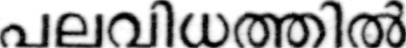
പലവിധത്തില്‍
